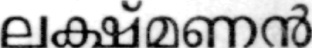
ലക്ഷ്മണന്‍
